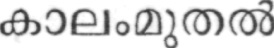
കാലംമുതല്‍
